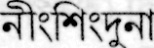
নীংশিংদুনা
